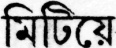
মিটিয়ে
